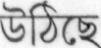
উঠিছে
